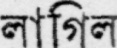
লাগিল
